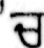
'ਚ
